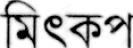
মিৎকপ
